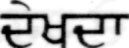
ਦੇਖਦਾ
